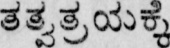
ತತ್ವತ್ರಯಕ್ಕೆ
